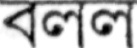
বলল
